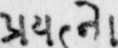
પ્રયત્નો
